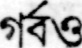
গর্বও
